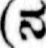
(ನ
